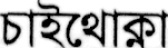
চাইথোক্না
